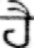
ਹੈ
